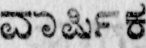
ವಾರ್ಷಿಕ
